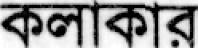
কলাকার
